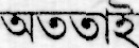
অততাই
